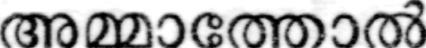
അമ്മാത്തോല്‍
